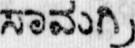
ಸಾಮಗ್ರಿ
